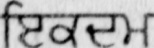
ਇਕਦਮ
